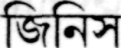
জিনিস
